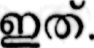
ഇത്.
